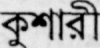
কুশারী
